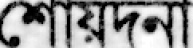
শোয়দনা
